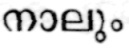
നാലും
